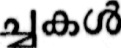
ച്ചകള്‍
